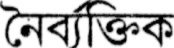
নৈর্ব্যক্তিক
